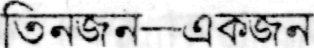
তিনজন—একজন
